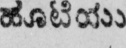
ಹೂಟೆಯು
